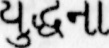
યુદ્ધના
